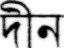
দীন
